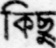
কিছু
